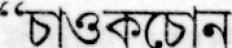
"চাওকচোন
